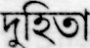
দুহিতা
